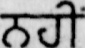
ਨਹੀਂ
